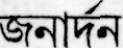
জনার্দন
